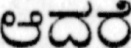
ಆದರೆ
